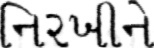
નિરખીને
